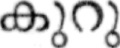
കുറു
